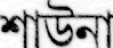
শাউনা
